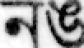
নঙ
